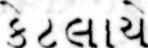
કેટલાયે
